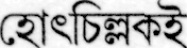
হোৎচিল্লকই
